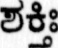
ಶಕ್ತಿಃ
